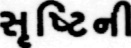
સૃષ્ટિની
